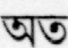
অত
